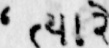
'ત્યારે
